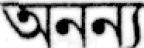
অনন্য
